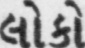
લોકો
